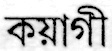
কয়াগী
